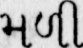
મળી
